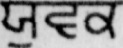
ਯੁਵਕ
